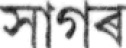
সাগৰ
